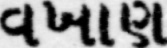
વખાણ
